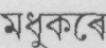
মধুকৰে
